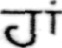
ਹਾਂ
